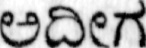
ಅದೀಗ
